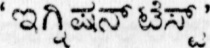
‘ಇಗ್ನಿಷನ್ ಟೆಸ್ಟ್’
